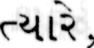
ત્યારે,
